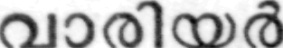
വാരിയര്‍
